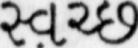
સ્વચ્છ
